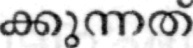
ക്കുന്നത്
